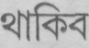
থাকিব
